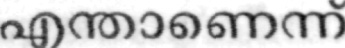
എന്താണെന്ന്
